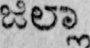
ಜಿಲ್ಲಾ
